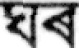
ঘৰ
